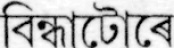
বিন্ধাটোৰে
